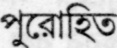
পুরোহিত
